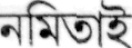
নমিতাই
